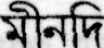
মীনদি
